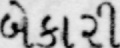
બેકારી
